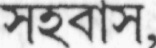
সহবাস,
